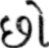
છો
